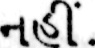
નહીં.
